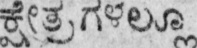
ಕ್ಷೇತ್ರಗಳಲ್ಲೂ
